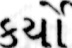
કર્યો
